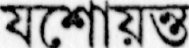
যশোয়ন্ত
